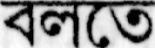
বলতে
